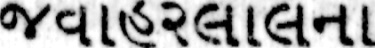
જવાહરલાલના
